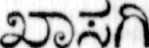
ಖಾಸಗಿ
